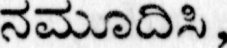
ನಮೂದಿಸಿ,
